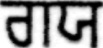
ਗਯ
